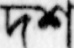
দশ
